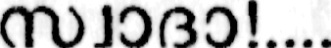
സ്വാദാ!....
